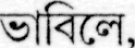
ভাবিলে,
